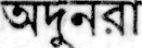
অদুনরা
